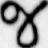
જ
